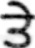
ਤੇ
